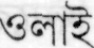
ওলাই
